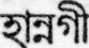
হান্নগী
